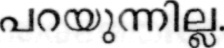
പറയുന്നില്ല.
